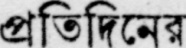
প্রতিদিনের
